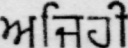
ਅਜਿਹੀ
